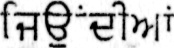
ਜਿਉਂਦੀਆਂ
